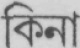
কিনা
